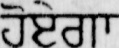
ਹੋਏਗਾ
